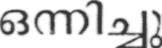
ഒന്നിച്ചു
